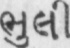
ભુલી
